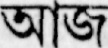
আজ
